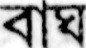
বাঘ
